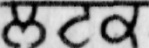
ਲਟਕ
